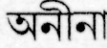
অনীনা
